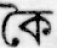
কৈ
